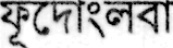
ফূদোংলবা
